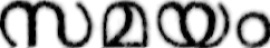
സമയം
